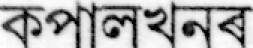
কপালখনৰ
